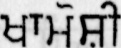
ਖਾਮੋਸ਼ੀ
